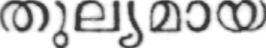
തുല്യമായ
